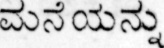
ಮನೆಯನ್ನು
